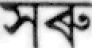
সৰু
